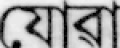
যোৱা
